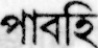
পাবহি
